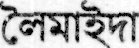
লৈমাইদা
